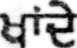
ਖਾਂਦੇ
